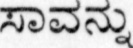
ಸಾವನ್ನು
